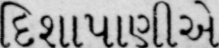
દિશાપાણીએ
